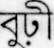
বুঢ়ী
